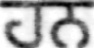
ਹਨ
